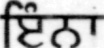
ਇੰਨਾ
